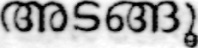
അടങ്ങൂ
